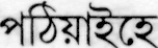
পঠিয়াইহে
